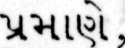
પ્રમાણે,
